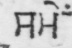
ਸਮੇਂ
